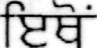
ਇਥੋਂ
